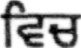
ਵਿਚ
